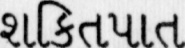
શક્તિપાત
